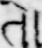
તો
